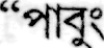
“পাবুং
